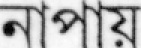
নাপায়
